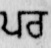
ਪਰ
